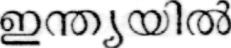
ഇന്ത്യയില്‍
